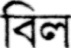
বিল
